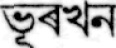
ভূৰখন
